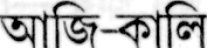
আজি-কালি
